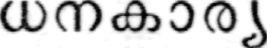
ധനകാര്യ
